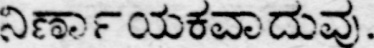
ನಿರ್ಣಾಯಕವಾದುವು.
